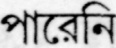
পারেনি
